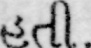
હતી.
